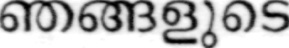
ഞങ്ങളുടെ
